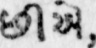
છીએ,
